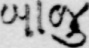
બાજુ
